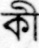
কী
